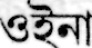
ওইনা
